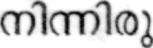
നിന്നിരു
